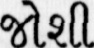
જોશી
